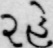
રહે
